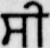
ਸੀ
